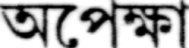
অপেক্ষা
